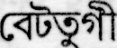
বেটতুগী
